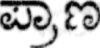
ಪ್ರಾಣ
